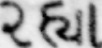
રહ્યા
